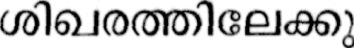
ശിഖരത്തിലേക്കു
